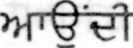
ਆਉਂਦੀ
